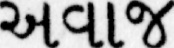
અવાજ
